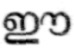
ഈ
